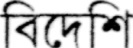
বিদেশি
